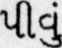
પીવું
